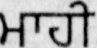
ਮਾਹੀ
